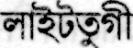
লাইটতুগী
